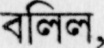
বলিল,
